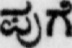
ಪುಗೆ
